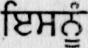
ਇਸਨੂੰ
